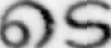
ടെ
